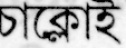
চাক্লোই
